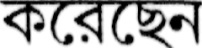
করেছেন
